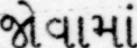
જોવામાં
